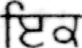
ਇਕ
